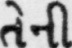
તેની
